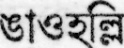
ঙাওহল্লি
